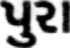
પુરા
